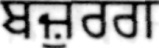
ਬਜ਼ੁਰਗ
